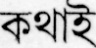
কথাই
